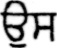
ਉਸ
